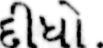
દીધો.
